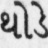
થોડે
